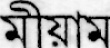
মীয়াম
